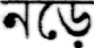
নড়ে
